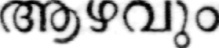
ആഴവും
